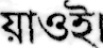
য়াওই।
